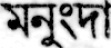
মনুংদা
